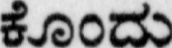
ಕೊಂದು
